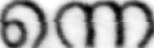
ന്നെ
